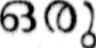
ഒരു
